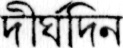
দীর্ঘদিন
